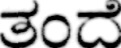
ತಂದೆ
